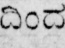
ದಿಂದ
